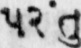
પરંતુ
